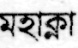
মহাক্না
